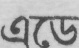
এড়ে
